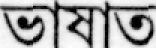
ভাষাত
